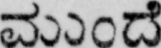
ಮುಂದೆ
